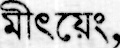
মীৎয়েং,
